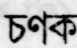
চণক
